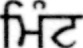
ਮਿੰਟ
